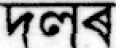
দলৰ
